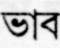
ভাব
